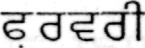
ਫ਼ਰਵਰੀ
